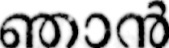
ഞാന്‍
